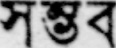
সম্ভব
